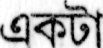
একটা
